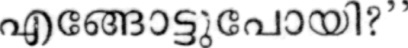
എങ്ങോട്ടുപോയി?"
